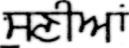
ਸੁਣੀਆਂ
